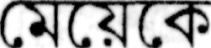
মেয়েকে
